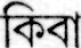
কিবা
